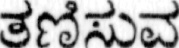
ತಣಿಸುವ
